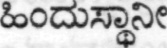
ಹಿಂದುಸ್ಥಾನೀ
